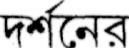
দর্শনের
